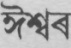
ঈশ্বৰ
